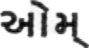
ઓમ્
